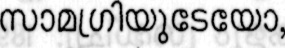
സാമഗ്രിയുടേയോ,
